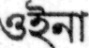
ওইনা
